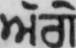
ਅੱਗੇ
